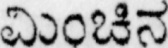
ಮಿಂಚಿನ
